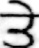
ਤੇ
